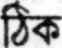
ঠিক
